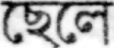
ছেলে
